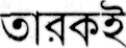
তারকই
